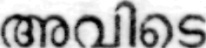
അവിടെ
